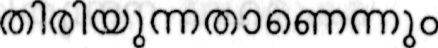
തിരിയുന്നതാണെന്നും
